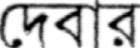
দেবার
